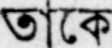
তাকে
